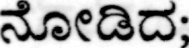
ನೋಡಿದ;
